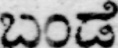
ಬಂಡೆ
